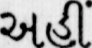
અહીં
